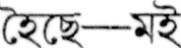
হৈছে-মই
